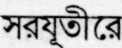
সরযূতীরে
